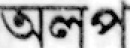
অলপ
